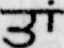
ਤਾਂ
